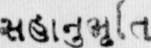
સહાનુભૂતિ
